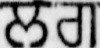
ਲਗ
